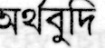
অর্থবুদি
